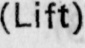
(Lift)
